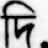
দি.
